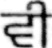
ਵੀ
